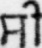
ਸੀ
